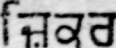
ਜ਼ਿਕਰ
